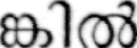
ങ്കില്‍
